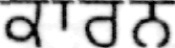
ਕਾਰਨ
